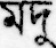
মদু
